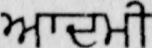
ਆਦਮੀ
